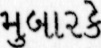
મુબારકે
